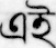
এই
